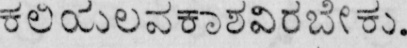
ಕಲಿಯಲವಕಾಶವಿರಬೇಕು.
